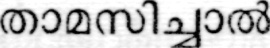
താമസിച്ചാല്‍
